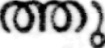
ത്തു
